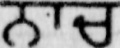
ਨਾਚ
